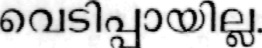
വെടിപ്പായില്ല.
